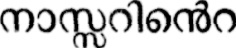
നാസ്സറിന്റെ
